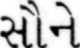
સૌને
